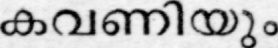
കവണിയും
